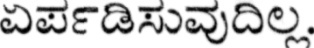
ಏರ್ಪಡಿಸುವುದಿಲ್ಲ.
